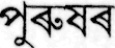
পুৰুষৰ
